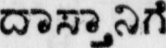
ದಾಸ್ತಾನಿಗೆ
